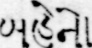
બહેનો
